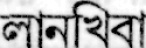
লানখিবা
